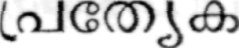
പ്രത്യേക
